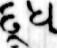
દૂધ
